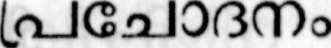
പ്രചോദനം
